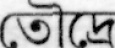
তৌদ্রে
